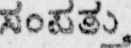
ಸಂಪತ್ತು
